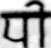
ਧੀ
